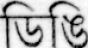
ডিঙি
